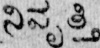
ನಿವೃತ್ತಿ
